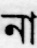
না
